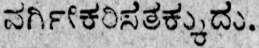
ವರ್ಗಿಕರಿಸತಕ್ಕದು.
